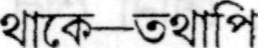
থাকে—তথাপি
